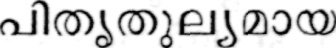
പിതൃതുല്യമായ
